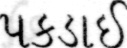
પકડાઈ
